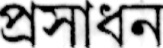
প্রসাধন
